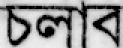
চলাব
